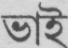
ভাই
